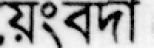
য়েংবদা
